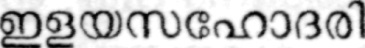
ഇളയസഹോദരി
